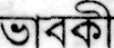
ভাবকী
